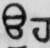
ਉਹ
